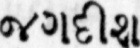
જગદીશ
